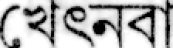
খেৎনবা
